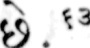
છે.૬૩
